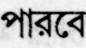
পারবে
